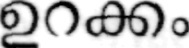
ഉറക്കം
